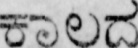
ಕಾಲದ
